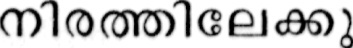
നിരത്തിലേക്കു
